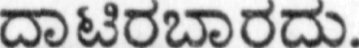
ದಾಟಿರಬಾರದು.
